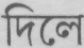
দিলে
